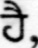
ਹੈ,
